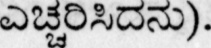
ಎಚ್ಚರಿಸಿದನು).
